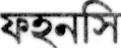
ফহনসি
